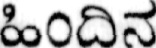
ಹಿಂದಿನ
